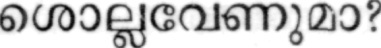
ശൊല്ലവേണുമാ?
